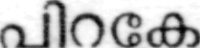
പിറകേ
